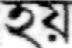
হয়
